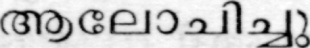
ആലോചിച്ചു
